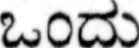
ಒಂದು
